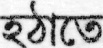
হঠাতে
